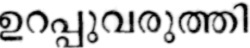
ഉറപ്പുവരുത്തി
